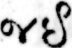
જઈ
